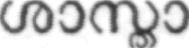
ശാസ്താ
